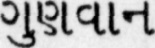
ગુણવાન
